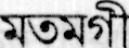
মতমগী
